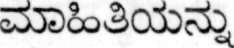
ಮಾಹಿತಿಯನ್ನು
